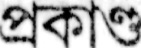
প্রকাণ্ড
